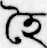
হৈ
